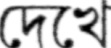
দেখে
